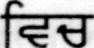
ਵਿਚ
